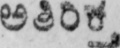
ಅತಿರಿಕ್ತ
